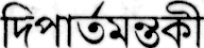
দিপার্তমন্তকী
